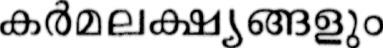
കര്‍മലക്ഷ്യങ്ങളും
